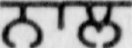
ਨਾਲ
